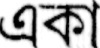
একা
